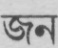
জন
